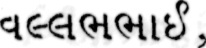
વલ્લભભાઈ,
